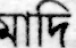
মাদি
